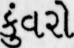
કુંવરો
